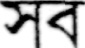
সব
